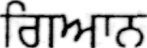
ਗਿਆਨ
